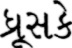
ધ્રૂસકે
